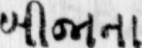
બીજાના
